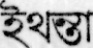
ইথন্তা
